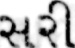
સરી
